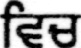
ਵਿਚ
